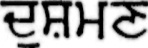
ਦੁਸ਼ਮਣ
